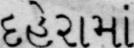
દહેરામાં
